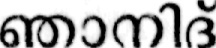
ഞാനിദ്
